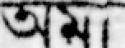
অমা
